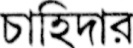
চাহিদার
